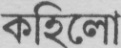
কহিলো
